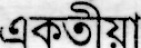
একতীয়া
